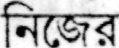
নিজের
